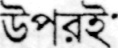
উপরই
